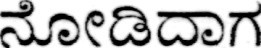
ನೋಡಿದಾಗ
